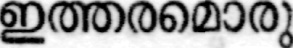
ഇത്തരമൊരു
